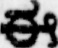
ಈ
